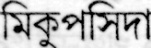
মিকুপসিদা
